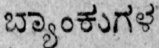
ಬ್ಯಾಂಕುಗಳ
